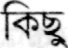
কিছু
